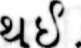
થઈ.
